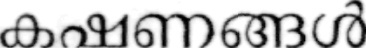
കഷണങ്ങള്‍
